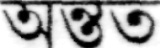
অন্তত
